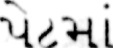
પેટમાં
